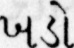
ખડો
